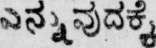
ಎನ್ನುವುದಕ್ಕೆ
